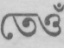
তেওঁ
